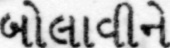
બોલાવીને
